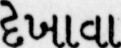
દેખાવા
